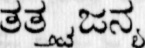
ತತ್ತ್ವಜನ್ಯ
